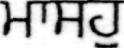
ਮਾਸਹੁ
